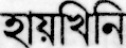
হায়খিনি
